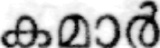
കമാര്‍
